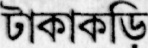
টাকাকড়ি
